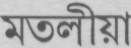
মতলীয়া
